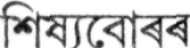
শিষ্যবোৰৰ
